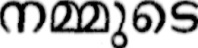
നമ്മുടെ
